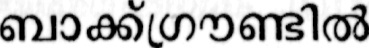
ബാക്ക്ഗ്രൌണ്ടില്‍
